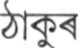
ঠাকুৰ
